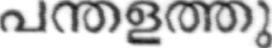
പന്തളത്തു
